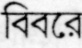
বিবরে
